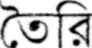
তৈরি
